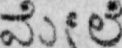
ಮೇಲೆ
